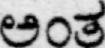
ಅ೦ತ
